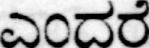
ಎಂದರೆ
